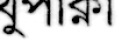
খুপাক্না
